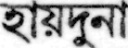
হায়দুনা
